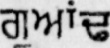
ਗੁਆਂਢ
